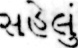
સહેલું
